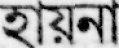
হায়না
